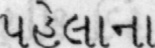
પહેલાના
